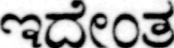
ಇದೇಂತ
